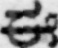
ಈ
